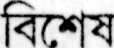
বিশেষ
